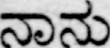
ನಾನು
